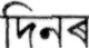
দিনৰ
